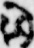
છે
